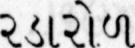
રડારોળ
